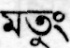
মতুং
